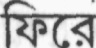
ফিরে
